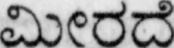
ಮೀರದೆ
